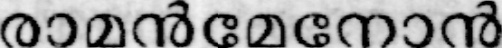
രാമന്‍മേനോന്‍
